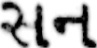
સન
